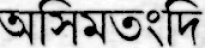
অসিমতংদি
